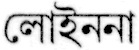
লোইননা
